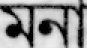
মনা
